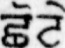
ਛੋਟੇ
